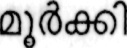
മൂര്‍ക്കി
